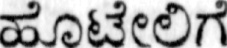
ಹೋಟೇಲಿಗೆ
